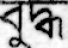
বুদ্ধ
